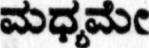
ಮಧ್ಯಮೇ
